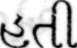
હતી
